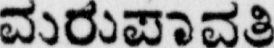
ಮರುಪಾವತಿ
